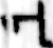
ન
